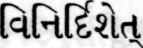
વિનિર્દિશેત્
